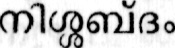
നിശ്ശബ്ദം
